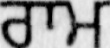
ਰਾਮ
